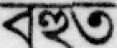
বহুত
